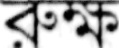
রুক্ষ
